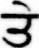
ਤੇ
